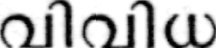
വിവിധ
